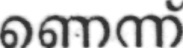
ണെന്ന്
